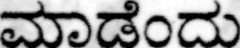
ಮಾಡೆಂದು
